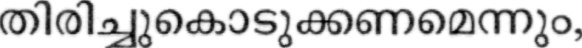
തിരിച്ചുകൊടുക്കണമെന്നും,
